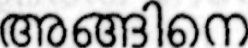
അങ്ങിനെ
